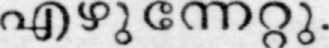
എഴുന്നേറ്റു.
